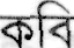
কবি
